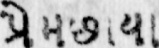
પ્રેમછાયા
